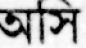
অসি
